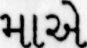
માએ
